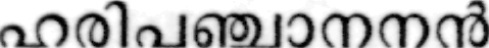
ഹരിപഞ്ചാനനന്‍
